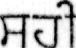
ਸਹੀ
